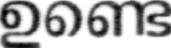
ഉണ്ടെ
